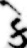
કે
